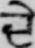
ਦੇ
